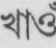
খাওঁ
